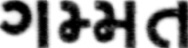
ગમ્મત
